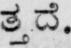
ತ್ತದೆ.
